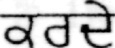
ਕਰਦੇ
